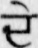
ਦੇ
